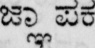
ಜ್ಞಾಪಕ
